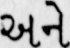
અને
